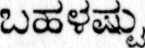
ಬಹಳಷ್ಟು
